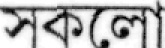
সকলো
